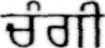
ਚੰਗੀ
